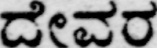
ದೇವರ
